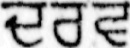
ਦਰਵ
